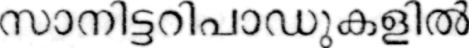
സാനിട്ടറിപാഡുകളില്‍
